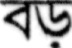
বড়
